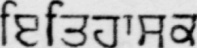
ਇਤਿਹਾਸਕ
